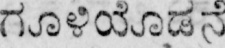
ಗೂಳಿಯೊಡನೆ
